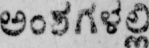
ಅಂಶಗಳಲ್ಲಿ
